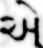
એ
